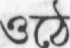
ওঠে
